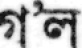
গ'ল
